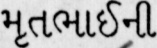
મૃતભાઈની
